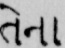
તેના
